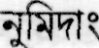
নুমিদাং
